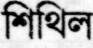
শিথিল
